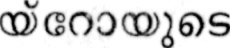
യ്റോയുടെ
